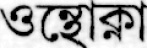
ওন্থোক্না
